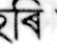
হৰি
